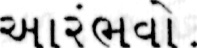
આરંભવો.
